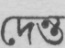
দেন্ত
